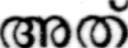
അത്
